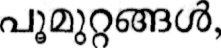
പൂമുറ്റങ്ങള്‍,
